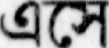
এসে
